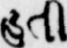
હતી
